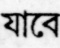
যাবে
